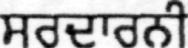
ਸਰਦਾਰਨੀ
